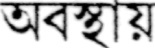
অবস্থায়
